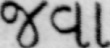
જવા
